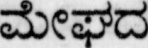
ಮೇಘದ
